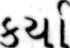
કર્યા
